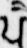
ਪੈ
